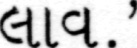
લાવ.'
